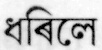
ধৰিলে
